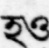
হও
